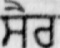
ਸੈਰ
